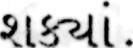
શક્યાં.
